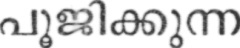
പൂജിക്കുന്ന
